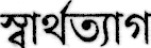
স্বার্থত্যাগ
